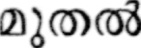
മുതല്‍
